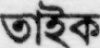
তাইক
